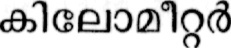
കിലോമീറ്റര്‍
